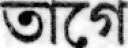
তাগে
